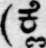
(ಕ್ಲೆ
